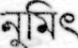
নুমিৎ
